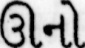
ઊનો
